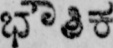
ಭೌತಿಕ
